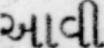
આવી
